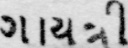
ગાયત્રી
